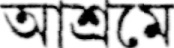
আশ্রমে
